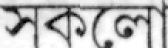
সকলো
